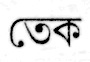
তেক
